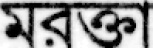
মরক্তা
